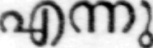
എന്നു
